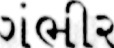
ગંભીર
